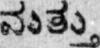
ಮತ್ತು
